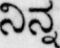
ನಿನ್ನ
